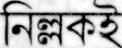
নিল্লকই
